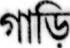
গাড়ি
